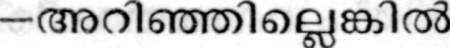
-അറിഞ്ഞില്ലെങ്കില്‍
